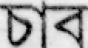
চাব
